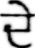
ਦੇ
